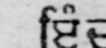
ਇੰਦ
